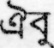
ঐবু
